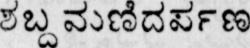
ಶಬ್ದಮಣಿದರ್ಪಣ
